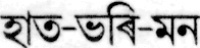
হাত-ভৰি-মন
